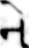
ને
